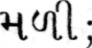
મળી;
